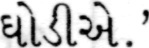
ઘોડીએ.'
